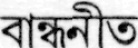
বান্ধনীত
